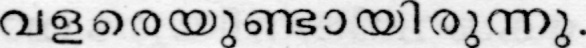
വളരെയുണ്ടായിരുന്നു.
